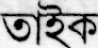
তাইক
